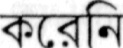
করেনি
